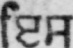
ਇਸ
